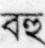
বহু
